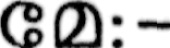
മേ:-
